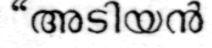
“അടിയന്‍
